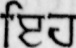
ਇਹ
